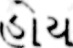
હોય
